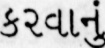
કરવાનું
